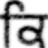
ਕਿ
